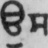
ਉਸ
